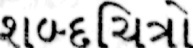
શબ્દચિત્રો
